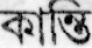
কান্তি
